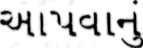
આપવાનું
